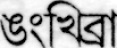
ঙংখিব্রা
